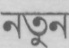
নতুন
